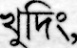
খুদিং,
